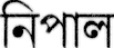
নিপাল
